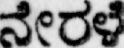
ನೇರಳೆ
